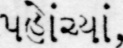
પહોંચ્યાં,
